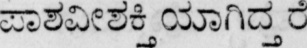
ಪಾಶವೀಶಕ್ತಿಯಾಗಿದ್ದರೆ
